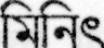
মিনিৎ
